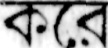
করে
